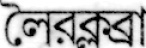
লৈরক্লব্রা
